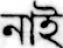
নাই
